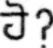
ਹੋ?
